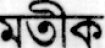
মতীক
